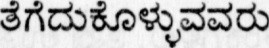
ತೆಗೆದುಕೊಳ್ಳುವವರು
